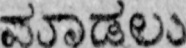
ಮಾಡಲು
